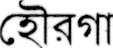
হৌরগা
